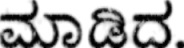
ಮಾಡಿದ.
